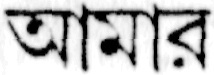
আমার
